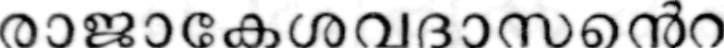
രാജാകേശവദാസന്റെ
